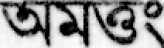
অমত্তং
